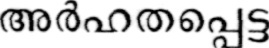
അര്‍ഹതപ്പെട്ട
